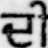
ਦੀ
